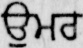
ਉਮਰ
